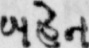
બહેન
